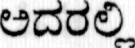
ಅದರಲ್ಲಿ
